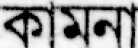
কামনা
